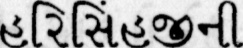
હરિસિંહજીની
